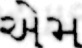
એમ
